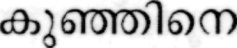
കുഞ്ഞിനെ
